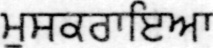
ਮੁਸਕਰਾਇਆ
